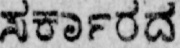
ಸರ್ಕಾರದ
